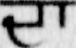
ਦਾ
